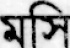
মসি
